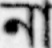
না
